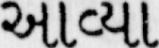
આવ્યા
